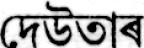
দেউতাৰ
